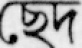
ছেদ
